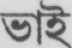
ভাই
